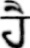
ਹੈ
